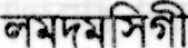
লমদমসিগী
